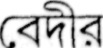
বেদীর
